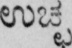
ಉಚ್ಛ
